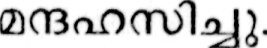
മന്ദഹസിച്ചു.
